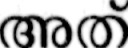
അത്
